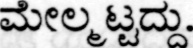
ಮೇಲ್ಮಟ್ಟದ್ದು.
